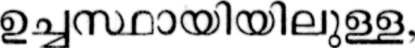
ഉച്ചസ്ഥായിയിലുള്ള,
